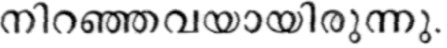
നിറഞ്ഞവയായിരുന്നു.
